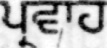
ਪ੍ਰਵਾਹ
